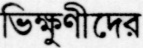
ভিক্ষুণীদের
